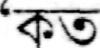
‘কত
